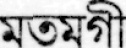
মতমগী
